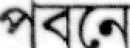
পবনে
